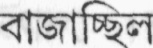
বাজাচ্ছিল
